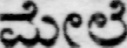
ಮೇಲೆ
